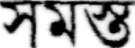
সমস্ত
